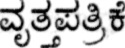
ವೃತ್ತಪತ್ರಿಕೆ
